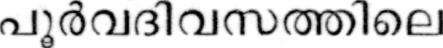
പൂര്‍വദിവസത്തിലെ
